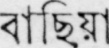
বাছিয়া
